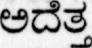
ಅದೆತ್ತ
